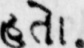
હતો.
